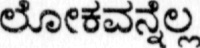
ಲೋಕವನ್ನೆಲ್ಲ
